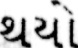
થયો
